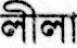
লীলা
